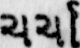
ચર્ચા
